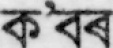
ক'বৰ
